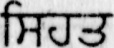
ਸਿਹਤ
